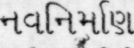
નવનિર્માણ
